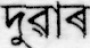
দুৱাৰ
